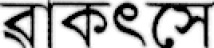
ৱাকৎসে
